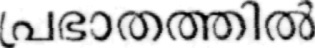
പ്രഭാതത്തില്‍
